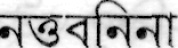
নত্তবনিনা
